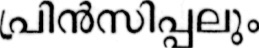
പ്രിന്‍സിപ്പലും
